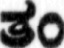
ತಂ
